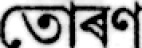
তোৰণ
